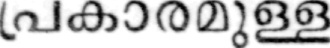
പ്രകാരമുള്ള
